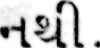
નથી.
